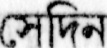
সেদিন
